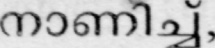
നാണിച്ച്,
